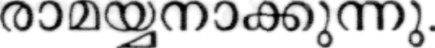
രാമയ്യനാക്കുന്നു.
